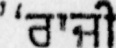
''ਰਾਜੀ
